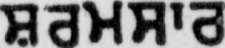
ਸ਼ਰਮਸਾਰ
